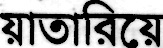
য়াতারিয়ে
